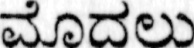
ಮೊದಲು
